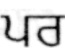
ਪਰ
